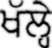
ਖੱਲ੍ਹੇ
